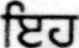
ਇਹ
